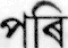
পৰি
